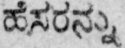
ಹೆಸರನ್ನು
